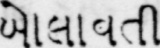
બોલાવતી
